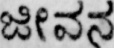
ಜೀವನ
